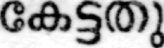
കേട്ടതു
